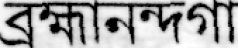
ব্রহ্মানন্দগা
